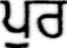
ਪੁਰ
